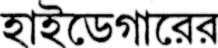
হাইডেগারের
